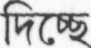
দিচ্ছে
